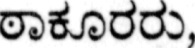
ಠಾಕೂರರು,
